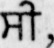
ਸੀ,
